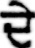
ਦੇ
